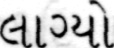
લાગ્યો
